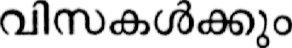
വിസകള്‍ക്കും
